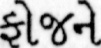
ફોજને
